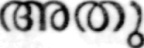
അതു
